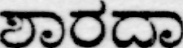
ಶಾರದಾ
